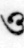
ও
